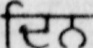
ਦਿਨ
